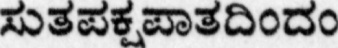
ಸುತಪಕ್ಷಪಾತದಿಂದಂ
